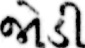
જોડી
